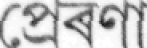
প্রেৰণা
